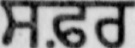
ਸਫ਼ਰ
